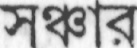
সঞ্চার
